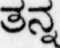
ತನ್ನ
